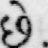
છે.
